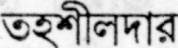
তহশীলদার
